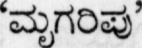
‘ಮೃಗರಿಪು’
